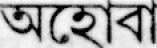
অহোবা
